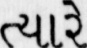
ત્યારે
